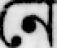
নে
